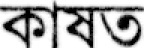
কাষত
